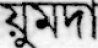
য়ুমদা
